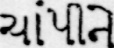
ચાંપીને
